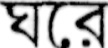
ঘরে
